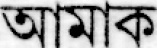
আমাক
